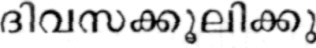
ദിവസക്കൂലിക്കു
